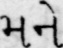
મને
